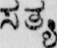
ಸತ್ಯ
